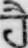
ਹੈ
